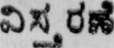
ವಿಸ್ತರಣೆ
